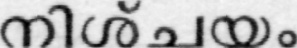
നിശ്ചയം
